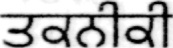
ਤਕਨੀਕੀ
